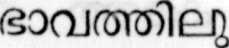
ഭാവത്തിലു
